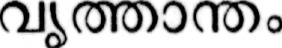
വൃത്താന്തം
